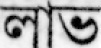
লাভ
